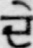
ਦੇ
